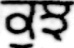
ਕੁਝ
